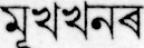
মূখখনৰ
